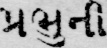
પ્રભુની
